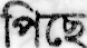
পিছে
